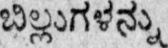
ಬಿಲ್ಲುಗಳನ್ನು
